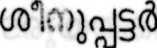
ശീനുപ്പട്ടര്‍
